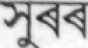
সুৰৰ
